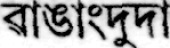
ৱাঙাংদুদা
